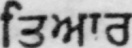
ਤਿਆਰ
